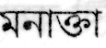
মনাক্তা
